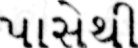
પાસેથી
